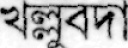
খল্লুবদা
